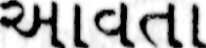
આવતા
